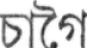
চাগৈ
